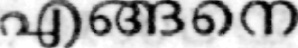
എങ്ങനെ
